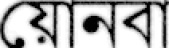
য়োনবা
